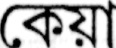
কেয়া
